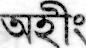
অহীং
